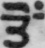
ਤੋਂ
